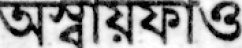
অস্বায়ফাও
